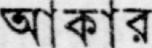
আকার
